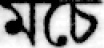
মচে
